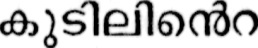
കുടിലിന്റെ
